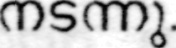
നടന്നു.
